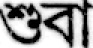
শুবা
